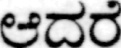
ಆದರೆ
